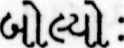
બોલ્યો:
